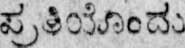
ಪ್ರತಿಯೊಂದು
